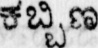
ಕಬ್ಬಿಣ
